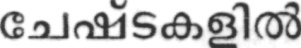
ചേഷ്ടകളില്‍
